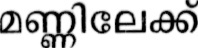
മണ്ണിലേക്ക്
